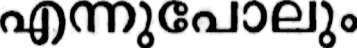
എന്നുപോലും
